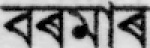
বৰমাৰ
